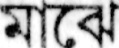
মাঝে
